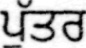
ਪੁੱਤਰ
